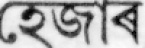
হেজাৰ
